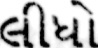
લીધો
